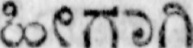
ಹೀಗಾಗಿ
